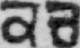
ਕਰ
